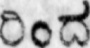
ರಿಂದ
